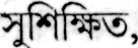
সুশিক্ষিত,
